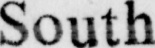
South
